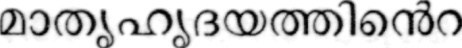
മാതൃഹൃദയത്തിന്റെ
